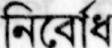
নির্বোধ
